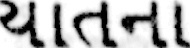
યાતના
